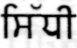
ਸਿੱਧੀ
